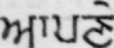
ਆਪਣੇ
